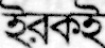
ইরকই
